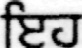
ਇਹ
